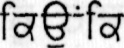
ਕਿਉਂਕਿ
